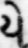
યે
